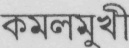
কমলমুখী
